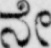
ನೇ
